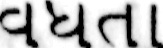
વધતા
